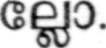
ല്ലോ.
